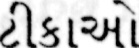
ટીકાઓ
